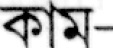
কাম-
